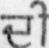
ਦੀ
